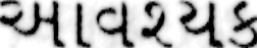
આવશ્યક
